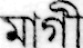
মাগী
